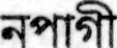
নপাগী
